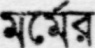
মর্মের
